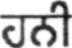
ਹਨੀ
